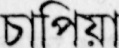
চাপিয়া
